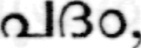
പദം,
